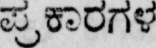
ಪ್ರಕಾರಗಳ
